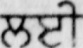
ਲਈ
